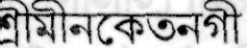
শ্রীমীনকেতনগী
